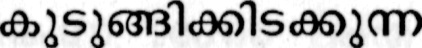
കുടുങ്ങിക്കിടക്കുന്ന
